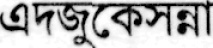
এদজুকেসন্না
